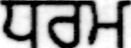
ਧਰਮ
